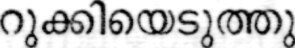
റുക്കിയെടുത്തു
